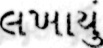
લખાયું
